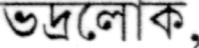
ভদ্রলোক,
